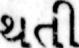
થતી
